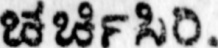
ಚರ್ಚಿಸಿರಿ.
